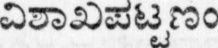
ವಿಶಾಖಪಟ್ಟಣಂ
